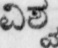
ವಿಶ್ವ
